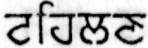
ਟਹਿਲਣ
